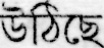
উঠিছে
